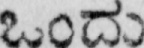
ಒಂದು
